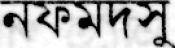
নফমদসু
